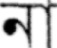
না
